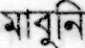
মাবুনি
